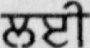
ਲਈ
